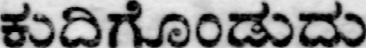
ಕುದಿಗೊಂಡುದು
